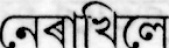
নেৰাখিলে
